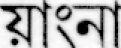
য়াংনা
